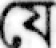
যে
